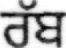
ਰੱਬ
